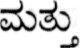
ಮತ್ತು
